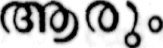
ആരും
